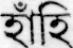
হাঁহি
